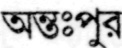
অন্তঃপুর
